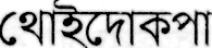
থোইদোকপা
